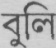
বুলি
